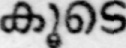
കൂടെ
